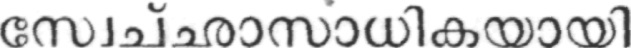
സ്വേച്ഛാസാധികയായി
